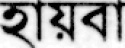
হায়বা
